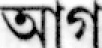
আগ
